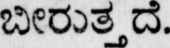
ಬೀರುತ್ತದೆ.
